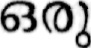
ഒരു
